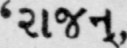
'રાજન્,
